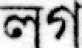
লগ
